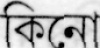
কিনো
